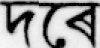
দৰে
